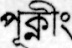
পূক্নীং
